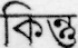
কিন্তু
